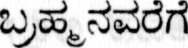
ಬ್ರಹ್ಮನವರೆಗೆ
